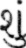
શું
